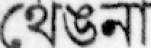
থেঙনা
